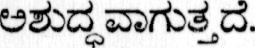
ಅಶುದ್ಧವಾಗುತ್ತದೆ.
